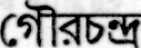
গৌরচন্দ্র
